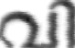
വി
